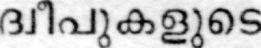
ദ്വീപുകളുടെ
